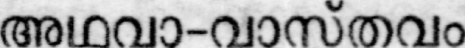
അഥവാ-വാസ്തവം
